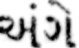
અંગે
